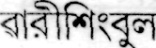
ৱারীশিংবুল
